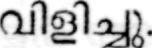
വിളിച്ചു.
